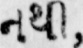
નથી,
